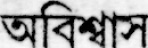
অবিশ্বাস
